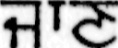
ਜਾਣ
